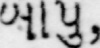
બાપુ,
